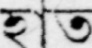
হাত
